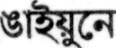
ঙাইয়ুনে
